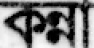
কন্না
